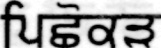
ਪਿਛੋਕੜ
